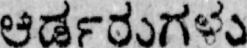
ಆರ್ಡರುಗಳು
